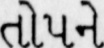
તોપને
